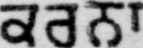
ਕਰਨਾ
